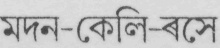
মদন-কেলি-ৰসে
